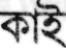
কাই
